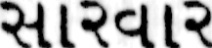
સારવાર
